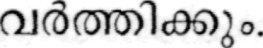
വര്‍ത്തിക്കും.
